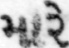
મારે
